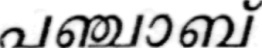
പഞ്ചാബ്
